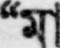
‘‘মা
